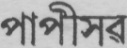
পাপীসৱ
